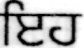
ਇਹ
